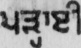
ਪੜ੍ਹਾਈ
